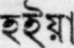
হইয়া
